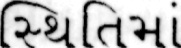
સ્થિતિમાં
